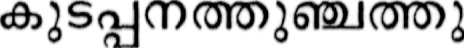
കുടപ്പനത്തുഞ്ചത്തു
